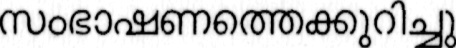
സംഭാഷണത്തെക്കുറിച്ചു
